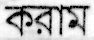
করাম
